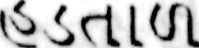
હડતાળ
